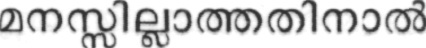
മനസ്സില്ലാത്തതിനാല്‍
